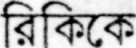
রিকিকে
